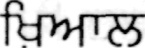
ਖ਼ਿਆਲ
